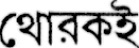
থোরকই
